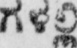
ಗಳಲ್ಲಿ
